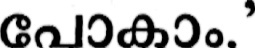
പോകാം.’
